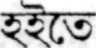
হইতে
